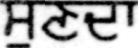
ਸੁਣਦਾ
